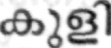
കുളി
